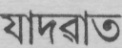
যাদৱাত
